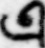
এ
